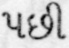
પછી
